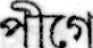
পীগে
